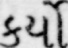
કર્યો
